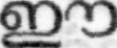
ഈ
